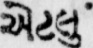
એટલું
